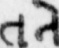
તને
